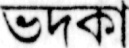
ভদকা
